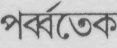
পৰ্ব্বতেক
